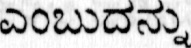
ಎಂಬುದನ್ನು
